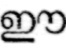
ഈ
